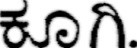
ಕೂಗಿ.
